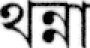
থন্না
